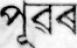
পূৱৰ
